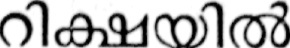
റിക്ഷയില്‍
